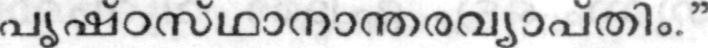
പൃഷ്ഠസ്ഥാനാന്തരവ്യാപ്തിം."
